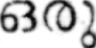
ഒരു
